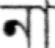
না
